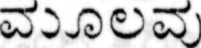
ಮೂಲವು
